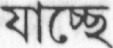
যাচ্ছে
